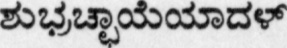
ಶುಭ್ರಚ್ಛಾಯೆಯಾದಳ್
